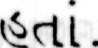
હતાં.
